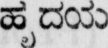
ಹೃದಯ
